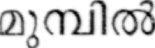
മുമ്പില്‍
